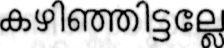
കഴിഞ്ഞിട്ടല്ലേ
